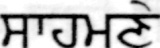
ਸਾਹਮਣੇ
